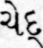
ચેદ્
